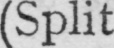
(Split
